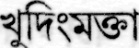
খুদিংমক্তা
